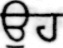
ਉਹ
